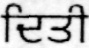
ਦਿਤੀ
